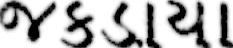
જકડાયા
